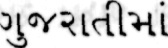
ગુજરાતીમાં
